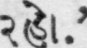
રહો.'
